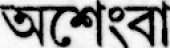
অশেংবা
